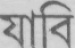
যাবি
